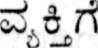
ವ್ಯಕ್ತಿಗೆ
